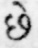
છે
